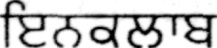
ਇਨਕਲਾਬ
